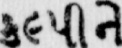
કલ્પીને
